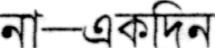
না–একদিন
